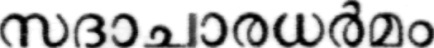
സദാചാരധര്‍മം
